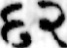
દર
